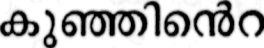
കുഞ്ഞിന്റെ
